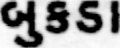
બુકડા
